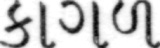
કાગળ
